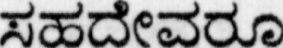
ಸಹದೇವರೂ
